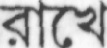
রাখে
